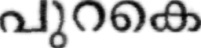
പുറകെ
